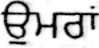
ਉਮਰਾਂ
